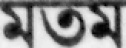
মতম
